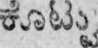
ಕೊಟ್ಟು
